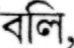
বলি,
